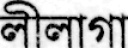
লীলাগা
